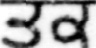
ਤਕ
